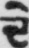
ਦੇ
